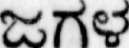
ಜಗಳ
